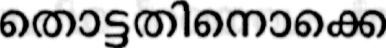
തൊട്ടതിനൊക്കെ
